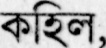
কহিল,
